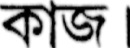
কাজ।
